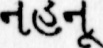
નહનૂ
